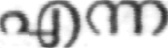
എന്ന
